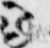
છે
